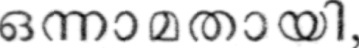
ഒന്നാമതായി,
